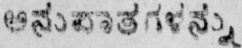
ಅನುಪಾತಗಳನ್ನು
